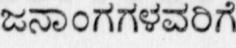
ಜನಾಂಗಗಳವರಿಗೆ
